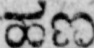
ಹಣ
